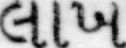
લાખ
